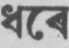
ধৰে
